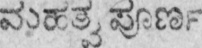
ಮಹತ್ವಪೂರ್ಣ
